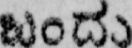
ಬಂದು
